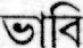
ভাবি
